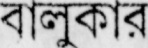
বালুকার
